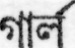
গার্ল
